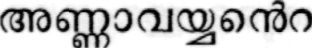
അണ്ണാവയ്യന്റെ
